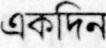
একদিন
